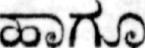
ಹಾಗೂ
